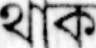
থাক
